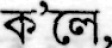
ক'লে,
